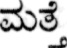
ಮತ್ತೆ
